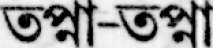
তপ্না-তপ্না
